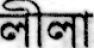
লীলা
